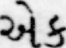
એક
